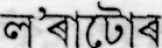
ল'ৰাটোৰ
